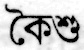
কৈশু
